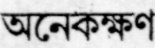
অনেকক্ষণ
